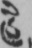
હૈ,
